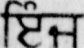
ਇੰਜ
